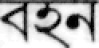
বহন
